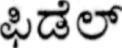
ಫಿಡೆಲ್
